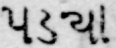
પડ્યા
